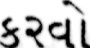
કરવો
